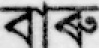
বাৰু
